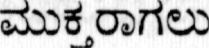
ಮುಕ್ತರಾಗಲು
